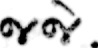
જજે.
